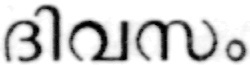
ദിവസം
